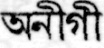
অনীগী
